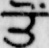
ਤੋਂ
